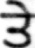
ਤੇ
